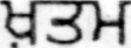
ਖ਼ਤਮ
